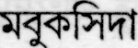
মবুকসিদা
